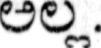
ಅಲ್ಲ.
